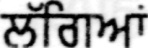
ਲੱਗਿਆਂ
